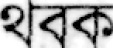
থবক
